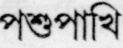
পশুপাখি
